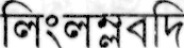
লিংলম্লবদি
